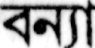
বন্যা
